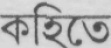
কহিতে
